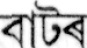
বাটৰ
